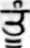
ਤੂੰ
